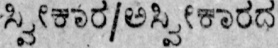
ಸ್ವೀಕಾರ/ಅಸ್ವೀಕಾರದ
